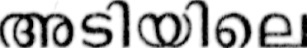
അടിയിലെ
